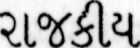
રાજકીય
